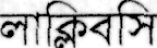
লাক্লিবসি
